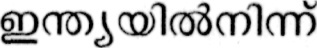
ഇന്ത്യയില്‍നിന്ന്
